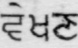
ਵੇਖਣ
